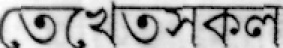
তেখেতসকল
